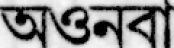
অওনবা
